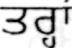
ਤਰ੍ਹਾਂ
